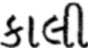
કાલી
